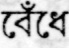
বেঁধে
